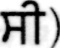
ਸੀ)
